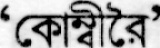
‘কোম্বীরৈ’
